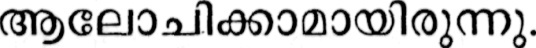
ആലോചിക്കാമായിരുന്നു.
